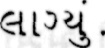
લાગ્યું.
